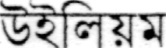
উইলিয়ম
